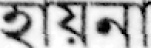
হায়না
